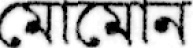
মোমোন
